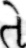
તે
